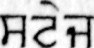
ਸਟੇਜ
